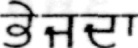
ਭੇਜਦਾ
